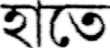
হাতে
